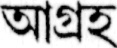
আগ্রহ
